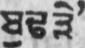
ਬੁਢੜੇ'
